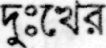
দুঃখের
